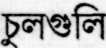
চুলগুলি
